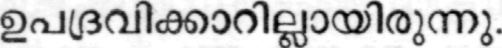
ഉപദ്രവിക്കാറില്ലായിരുന്നു.
